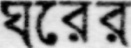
ঘরের
